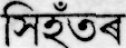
সিহঁতৰ
